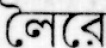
লৈরে
